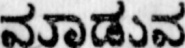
ಮಾಡುವ
